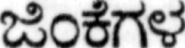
ಜಿಂಕೆಗಳ
